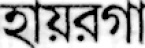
হায়রগা
